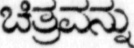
ಚಿತ್ರವನ್ನು
